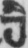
ਹੈ
